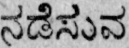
ನಡೆಸುವ
